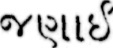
જણાઈ
